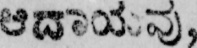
ಆದಾಯವು,
